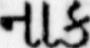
નાક
